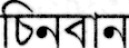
চিনবান
